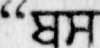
''ਬਸ
